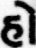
હો
